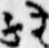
કરે
